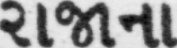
રાજાના
